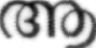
ആ
